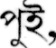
পুই,
